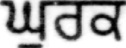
ਘੁਰਕ
